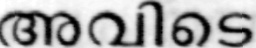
അവിടെ
